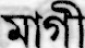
মাগী
